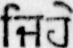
ਜਿਹੇ
